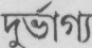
দুৰ্ভাগ্য
